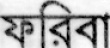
ফরিবা
